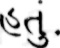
હતું.
